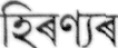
হিৰণ্যৰ
